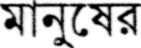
মানুষের
